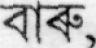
বাৰু,
